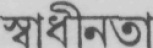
স্বাধীনতা
